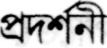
প্রদর্শনী
